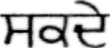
ਸਕਦੇ
